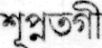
শূপ্নতগী
